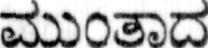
ಮುಂತಾದ
